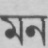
মন
